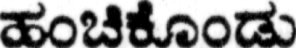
ಹಂಚಿಕೊಂಡು
